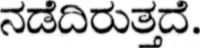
ನಡೆದಿರುತ್ತದೆ.
